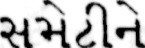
સમેટીને
